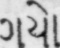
ગયો
